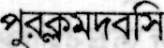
পুরক্লমদবসি
